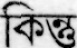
কিন্তু
